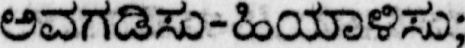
ಅವಗಡಿಸು-ಹಿಯಾಳಿಸು;
